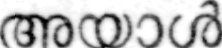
അയാള്‍
